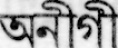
অনীগী
